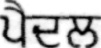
ਪੈਦਲ
